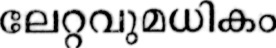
ലേറ്റവുമധികം
